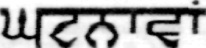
ਘਟਨਾਵਾਂ
